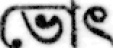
ভোৎ
